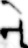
ને
